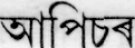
আপিচৰ
